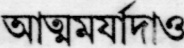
আত্মমর্যাদাও
